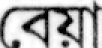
বেয়া
